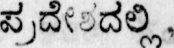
ಪ್ರದೇಶದಲ್ಲಿ,
